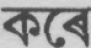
কৰে
